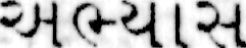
અભ્યાસ
